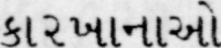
કારખાનાઓ
